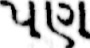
પણ
